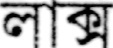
লাক্স
